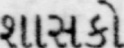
શાસકો
